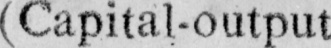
(Capital-output
